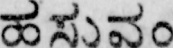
ಹಸುವಂ
